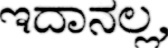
ಇದಾನಲ್ಲ,
